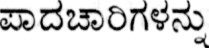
ಪಾದಚಾರಿಗಳನ್ನು
